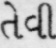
તેવી
